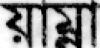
য়াম্না
